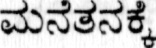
ಮನೆತನಕ್ಕೆ
